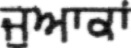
ਜੁਆਕਾਂ
